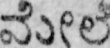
ಮೇಲೆ
